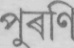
পুৰণি
